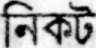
নিকট
